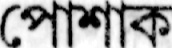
পোশাক
